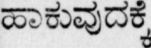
ಹಾಕುವುದಕ್ಕೆ
